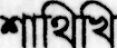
শাথিখি
